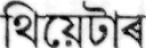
থিয়েটাৰ
